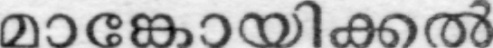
മാങ്കോയിക്കല്‍
